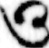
ও
